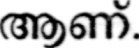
ആണ്.
